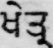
ਖੇਤ੍ਰ
